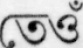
তেওঁ
